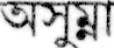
অসুম্না
